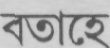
বতাহে
